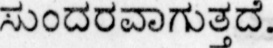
ಸುಂದರವಾಗುತ್ತದೆ.
